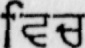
ਵਿਚ
